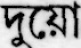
দুয়ো
